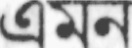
এমন
